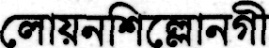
লোয়নশিল্লোনগী
